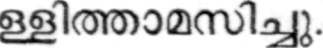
ള്ളിത്താമസിച്ചു.
